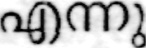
എന്നു
